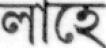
লাহে
